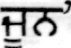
ਜੂਨ'
